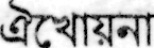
ঐখোয়না
